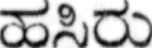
ಹಸಿರು
